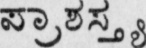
ಪ್ರಾಶಸ್ತ್ಯ
